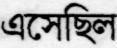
এসেছিল
